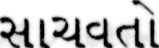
સાચવતો
